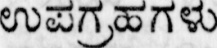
ಉಪಗ್ರಹಗಳು
